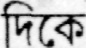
দিকে
